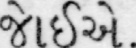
જોઈએ.
